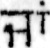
ਜਾਂ
